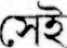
সেই
